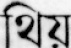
থিয়
